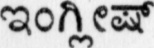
ಇಂಗ್ಲೀಷ್
